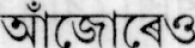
আঁজোৰেও
